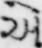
એ
